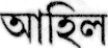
আহিল
